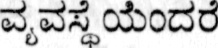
ವ್ಯವಸ್ಥೆಯೆಂದರೆ
